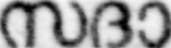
സദാ
